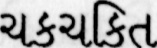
ચકચકિત
